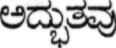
ಅದ್ಭುತವು
